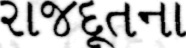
રાજદૂતના
